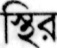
স্থির
